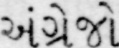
અંગ્રેજો
